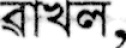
ৱাখল,
